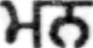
ਮਨ
